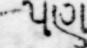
પણ
